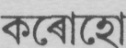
কৰোহো
